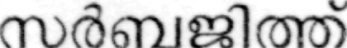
സര്‍ബജിത്ത്
